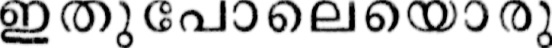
ഇതുപോലെയൊരു
